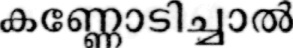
കണ്ണോടിച്ചാല്‍
